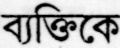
ব্যক্তিকে
